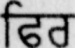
ਫਿਰ
